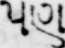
પણ
